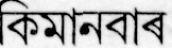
কিমানবাৰ
